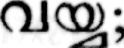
വയ്യ;
